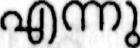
എന്നു
